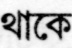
থাকে
